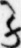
કે
